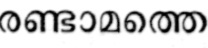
രണ്ടാമത്തെ
